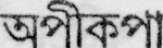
অপীকপা
